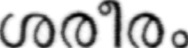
ശരീരം
